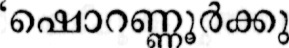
‘ഷൊറണ്ണൂര്‍ക്കു
